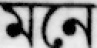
মনে
